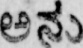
ಅನು
